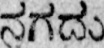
ನಗದು
